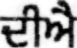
ਦੀਐ
